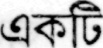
একটি
